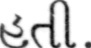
હતી.
